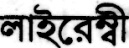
লাইরেম্বী
